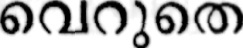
വെറുതെ
